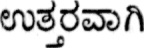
ಉತ್ತರವಾಗಿ
